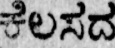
ಕೆಲಸದ
